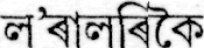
ল'ৰালৰিকৈ
